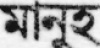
মানুহ
